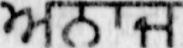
ਅਨਾਜ
